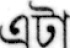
এটা
